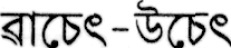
ৱাচেৎ-উচেৎ
